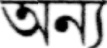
অন্য
